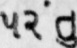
પરંતુ
